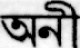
অনী
